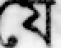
যে
